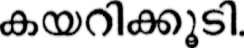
കയറിക്കൂടി.
